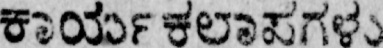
ಕಾರ್ಯಕಲಾಪಗಳು
